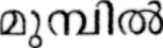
മുമ്പില്‍
